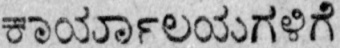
ಕಾರ್ಯಾಲಯಗಳಿಗೆ
